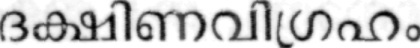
ദക്ഷിണവിഗ്രഹം
